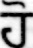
ਹੋ
